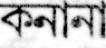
কনানা
